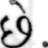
છે.
